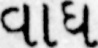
વાઘ
